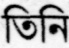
তিনি
